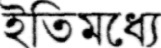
ইতিমধ্যে
